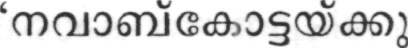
'നവാബ്കോട്ടയ്ക്കു
